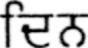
ਦਿਨ
